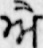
ਐ
